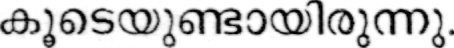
കൂടെയുണ്ടായിരുന്നു.
